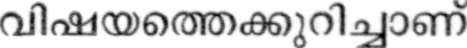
വിഷയത്തെക്കുറിച്ചാണ്
